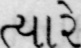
ત્યારે
